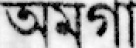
অমগা
